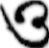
ও
